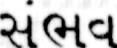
સંભવ
